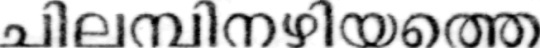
ചിലമ്പിനഴിയത്തെ
